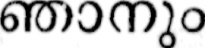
ഞാനും
